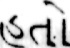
હતો
